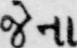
જેના
